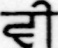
ਵੀ
